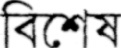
বিশেষ
